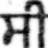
ਸੀ
